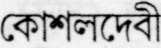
কোশলদেবী
